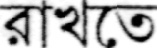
রাখতে
